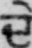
ਦੇ
